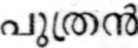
പുത്രന്‍
